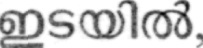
ഇടയില്‍,
